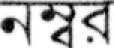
নম্বর
